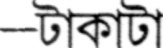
-টাকাটা
